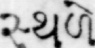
સ્થળે
